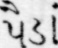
પૈડાં
